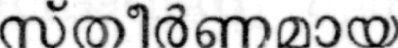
സ്തീര്‍ണമായ
